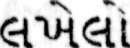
લખેલો
